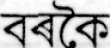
বৰকৈ
